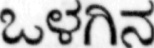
ಒಳಗಿನ
